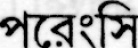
পরেংসি
